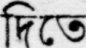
দিতে
